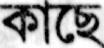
কাছে
